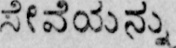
ಸೇವೆಯನ್ನು
